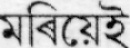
মৰিয়েই
